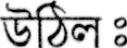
উঠিলঃ
